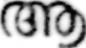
ആ
